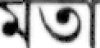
মতা
